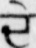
ਦੇ
